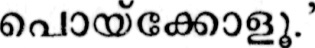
പൊയ്ക്കോളൂ.’
